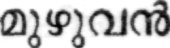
മുഴുവന്‍
